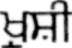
ਖ਼ੁਸ਼ੀ
